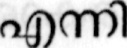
എന്നി
